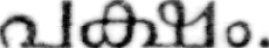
പക്ഷം.
